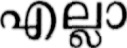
എല്ലാ
